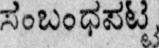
ಸಂಬಂಧಪಟ್ಟ
